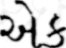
એક
